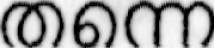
തന്നെ
